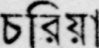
চরিয়া
